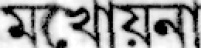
মখোয়না
